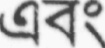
এবং
